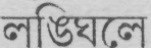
লঙিঘলে
